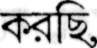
করছি,
